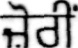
ਜ਼ੋਰੀਂ
